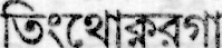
তিংথোক্নরগা
